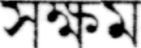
সক্ষম
